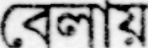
বেলায়
